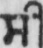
ਸੀ
